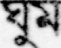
ঘুম
